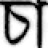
চা
